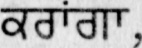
ਕਰਾਂਗਾ,
